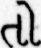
તો
